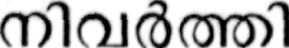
നിവര്‍ത്തി
